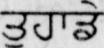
ਤੁਹਾਡੇ
